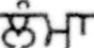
ਲੰਮਾ
